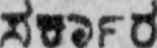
ಸರ್ಕಾರ
